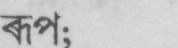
ৰূপ;
